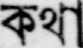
কথা
